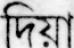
দিয়া
